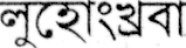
লুহোংখ্রবা
